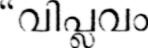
"വിപ്ലവം
